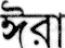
ঈরা
